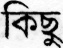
কিছু
